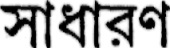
সাধারণ
